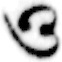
ও
